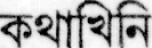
কথাখিনি
